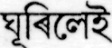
ঘূৰিলেই
